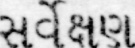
સર્વેક્ષણ
